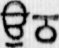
ਉਠ
